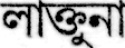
লাক্তুনা
